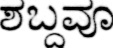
ಶಬ್ದವೂ
